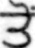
ਤੋਂ
